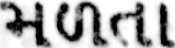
મળતા
